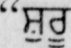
''ਸ਼ੁਰੂ
